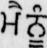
ਮੈਨੂੰ
